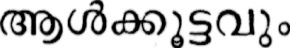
ആള്‍ക്കൂട്ടവും
